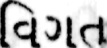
વિગત
